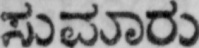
ಸುಮಾರು
